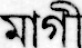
মাগী
